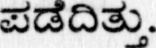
ಪಡೆದಿತ್ತು.
